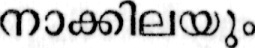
നാക്കിലയും
